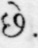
છે.
